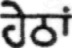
ਹੇਠਾਂ
